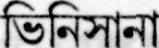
ভিনিসানা
